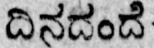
ದಿನದಂದೆ
